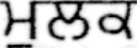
ਮੁਲਕ
